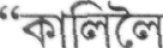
"কালিলৈ
